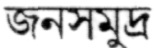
জনসমুদ্র
